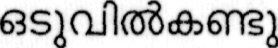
ഒടുവില്‍കണ്ടു
